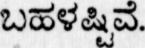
ಬಹಳಷ್ಟಿವೆ.
